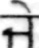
ਜੇ
